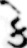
કે
